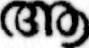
ആ
